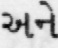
અને
